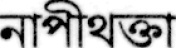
নাপীথক্তা
